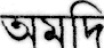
অমদি
